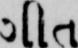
ગીત
